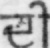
ਦੀ
